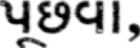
પૂછવા,
